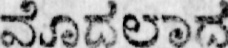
ಮೊದಲಾದ
